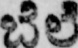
ಬೆಲೆ
